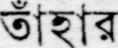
তাঁহার
